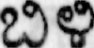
ಬಿಳಿ
